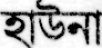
হাউনা
